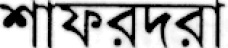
শাফরদরা
